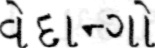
વેદાન્ગો
